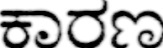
ಕಾರಣ
